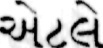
એટલે
